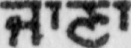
ਜਾਣਾ
